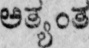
ಅತ್ಯಂತ
